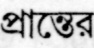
প্রান্তের
